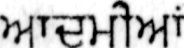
ਆਦਮੀਆਂ
